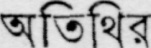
অতিথির
